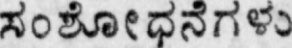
ಸಂಶೋಧನೆಗಳು
